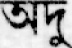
অদু
